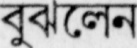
বুঝলেন
